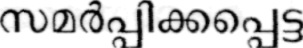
സമര്‍പ്പിക്കപ്പെട്ട
